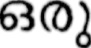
ഒരു
